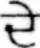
ਦੇ
